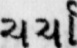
ચર્યા
